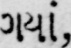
ગયાં,
